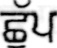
ਛੁੱਪ
